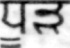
ਧੂੜ
